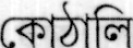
কোঠালি
